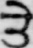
ਤੇ
